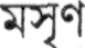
মসৃণ
